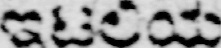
ಇಟಲಿಯ
